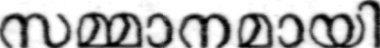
സമ്മാനമായി
